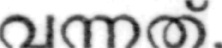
വന്നത്.
